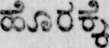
ಹೊರಕ್ಕೆ
